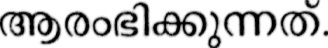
ആരംഭിക്കുന്നത്.
